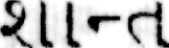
શાન્ત
